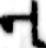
ન
